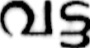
വട്ട
